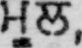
ਮੂਲ,
